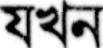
যখন
